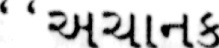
"અચાનક
